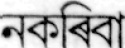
নকৰিবা
